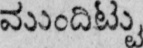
ಮುಂದಿಟ್ಟು
